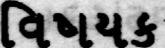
વિષયક
